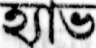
হ্যাভ
